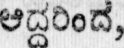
ಆದ್ದರಿಂದ,
